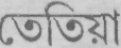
তেতিয়া
